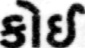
કોઈ
